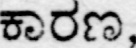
ಕಾರಣ,
